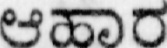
ಆಹಾರ
